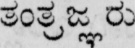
ತಂತ್ರಜ್ಞರು
